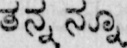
ತನ್ನನ್ನೂ
